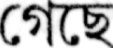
গেছে
